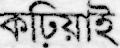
কঢ়িয়াই
